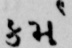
કર્મ
